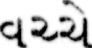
વચ્ચે
